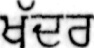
ਖੱਦਰ
